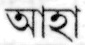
আহা
